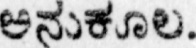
ಅನುಕೂಲ.
